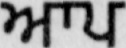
ਆਪ
